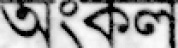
অংকল
